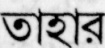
তাহার
